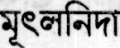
মূৎলনিদা
